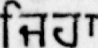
ਜਿਹਾ
